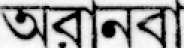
অরানবা
